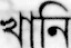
খানি
